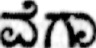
ವೆಗಾ
